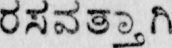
ರಸವತ್ತಾಗಿ
